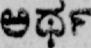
ಅರ್ಥ
